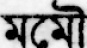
মমৌ
